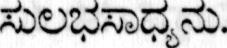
ಸುಲಭಸಾಧ್ಯನು.
